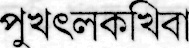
পুখৎলকখিবা
